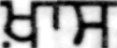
ਖ਼ਾਸ
